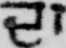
ਦਾ
